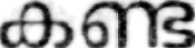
കണ്ട
